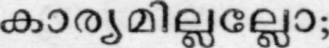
കാര്യമില്ലല്ലോ;
